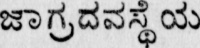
ಜಾಗ್ರದವಸ್ಥೆಯ
